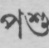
পশু
